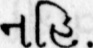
નહિ.
